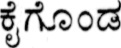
ಕೈಗೊಂಡ
